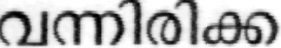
വന്നിരിക്ക
